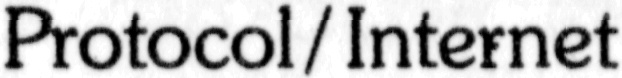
Protocol/Internet
